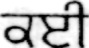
ਕਈ
